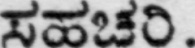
ಸಹಚರಿ.
